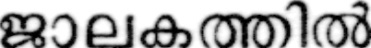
ജാലകത്തില്‍
